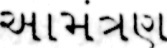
આમંત્રણ
